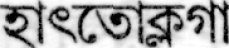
হাৎতোক্লগা
